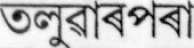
তলুৱাৰপৰা
